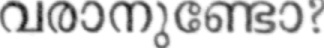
വരാനുണ്ടോ?
